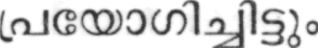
പ്രയോഗിച്ചിട്ടും
